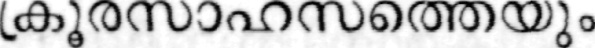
ക്രൂരസാഹസത്തെയും
